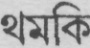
থমকি
